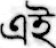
এই
